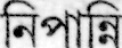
নিপান্নি
